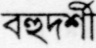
বহুদর্শী
